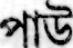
পাউ
